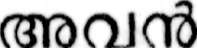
അവന്‍
